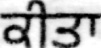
ਕੀਤਾ
